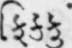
ફિક્કું
